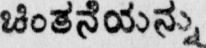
ಚಿಂತನೆಯನ್ನು
